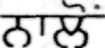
ਨਾਲੋਂ
